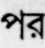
পর
